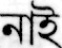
নাই
